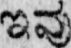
ಇವು
